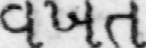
વખત
